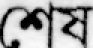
শেষ
